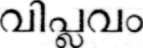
വിപ്ലവം
